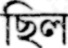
ছিল
